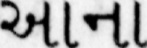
આના
